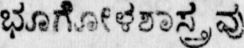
ಭೂಗೋಳಶಾಸ್ತ್ರವು
